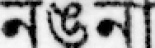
নঙনা
